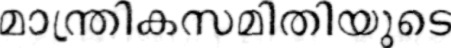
മാന്ത്രികസമിതിയുടെ
